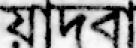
য়াদবা
